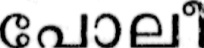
പോലീ
